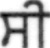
ਸੀ
